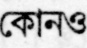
কোনও
